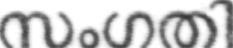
സംഗതി
